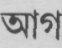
আগ
